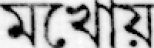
মখোয়
